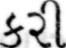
કરી
